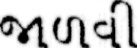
જાળવી
